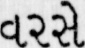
વરસે
